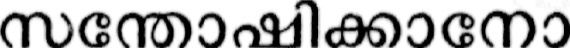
സന്തോഷിക്കാനോ
